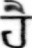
ਹੈ
